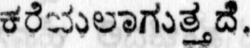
ಕರೆಯಲಾಗುತ್ತದೆ.
